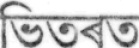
ভিতৰত
